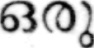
ഒരു
